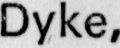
Dyke,
